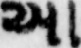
આ
